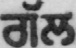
ਗੱਲ
